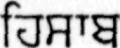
ਹਿਸਾਬ
